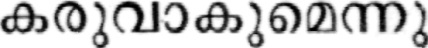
കരുവാകുമെന്നു
